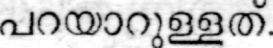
പറയാറുള്ളത്.
